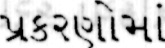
પ્રકરણોમાં
